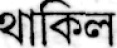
থাকিল
